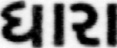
ધારા
